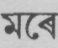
মৰে
